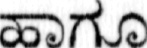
ಹಾಗೂ
